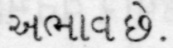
અભાવછે.
